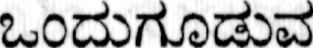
ಒಂದುಗೂಡುವ
